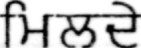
ਮਿਲਦੇ
